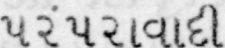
પરંપરાવાદી
